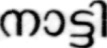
നാട്ടി
